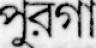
পুরগা
